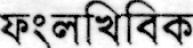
ফংলখিবিক
